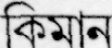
কিমান
